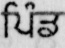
ਪਿੰਡ
